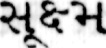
સૂક્ષ્મ
